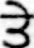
ਤੇ
